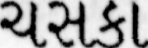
ચસકા
